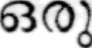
ഒരു
